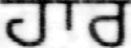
ਹਾਰ
